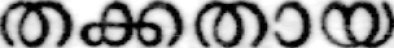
തക്കതായ
